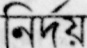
নির্দয়
